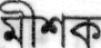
মীশক
